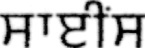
ਸਾਈਂਸ
